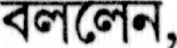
বললেন,
